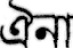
ঐনা
